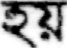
হয়
